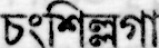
চংশিল্লগা
